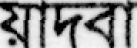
য়াদবা
